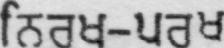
ਨਿਰਖ-ਪਰਖ
